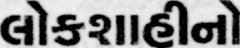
લોકશાહીનો
